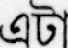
এটা
